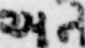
અને
